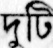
দুটি
